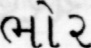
ભોર
